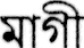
মাগী
